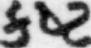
કષ્ટ
